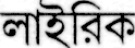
লাইরিক
